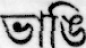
ভাঙি
